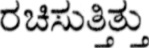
ರಚಿಸುತ್ತಿತ್ತು
